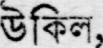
উকিল,
